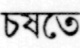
চষতে
